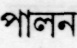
পালন
